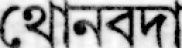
থোনবদা
